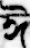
ঈ
